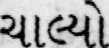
ચાલ્યો
